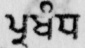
ਪ੍ਰਬੰਧ
